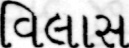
વિલાસ
